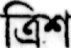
ত্রিশ
